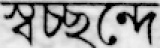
স্বচ্ছন্দে
